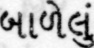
બાળેલું
